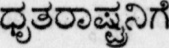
ಧೃತರಾಷ್ಟ್ರನಿಗೆ
